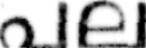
പല
